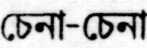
চেনা-চেনা
